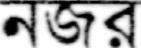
নজর
